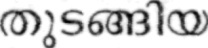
തുടങ്ങിയ
